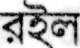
রইল
